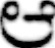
ಆ
